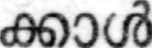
ക്കാള്‍
